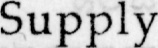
Supply
